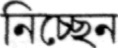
নিচ্ছেন
